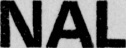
NAL
